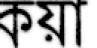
কয়া
